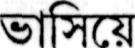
ভাসিয়ে
